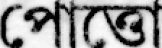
পোত্তো
